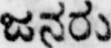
ಜನರು
